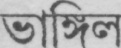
ভাঙ্গিল
